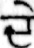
ਦੇ
